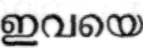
ഇവയെ
